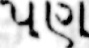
પણ
